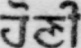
ਹੋਣੀ
